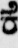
ಕೆ
